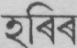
হৰিৰ
